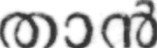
താന്‍
